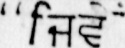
''ਜਿਵੇਂ
